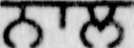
ਨਾਲ
